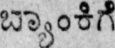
ಬ್ಯಾಂಕಿಗೆ
